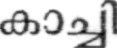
കാച്ചി
